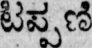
ಟಿಪ್ಪಣಿ
